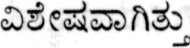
ವಿಶೇಷವಾಗಿತ್ತು
